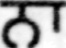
ਨਾ
